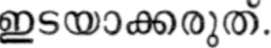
ഇടയാക്കരുത്.
